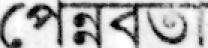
পেন্নবতা
